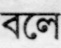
বলে
